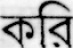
করি
